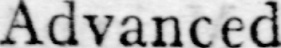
Advanced
